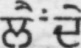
ਲੈਂਦੇ
